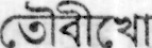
তৌবীখো
